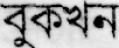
বুকখন
